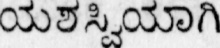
ಯಶಸ್ವಿಯಾಗಿ
